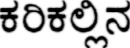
ಕರಿಕಲ್ಲಿನ
